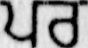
ਪਰ
